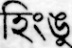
হিংঙু
